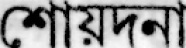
শোয়দনা
